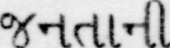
જનતાની
